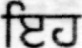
ਇਹ
